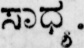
ಸಾಧ್ಯ.
